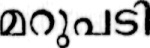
മറുപടി
